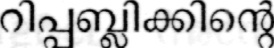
റിപ്പബ്ലിക്കിന്റെ
